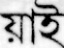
য়াই
